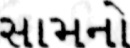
સામનો
